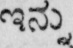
ಇನ್ನು
